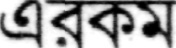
এরকম
